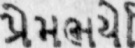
પ્રેમભર્યો
